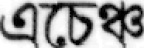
এচেঞ্চ
